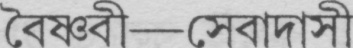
বৈষ্ণবী-সেবাদাসী
